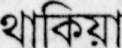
থাকিয়া
